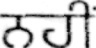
ਨਹੀਂ
